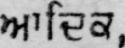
ਆਦਿਕ,
